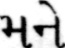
મને
